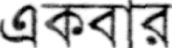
একবার
